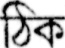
ঠিক
